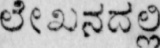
ಲೇಖನದಲ್ಲಿ
